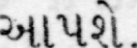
આપશે.
